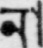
না
